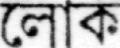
লোক
